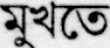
মুখতে
